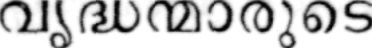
വൃദ്ധന്മാരുടെ
